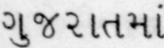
ગુજરાતમાં
